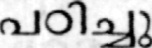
പഠിച്ചു
